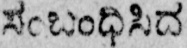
ಸಂಬಂಧಿಸಿದ
